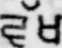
ਵੱਖ
